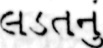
લડતનું
